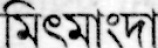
মিৎমাংদা
